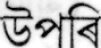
উপৰি
